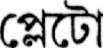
প্লেটো
